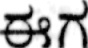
ಈಗ
